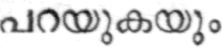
പറയുകയും
